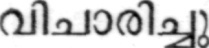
വിചാരിച്ചു
